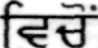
ਵਿਚੋਂ
